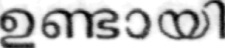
ഉണ്ടായി
